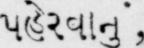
પહેરવાનું,
